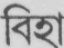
বিহা
